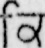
ਕਿ
